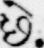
છે.
